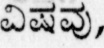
ವಿಷವು,
